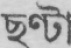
ছণ্টা
